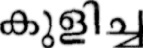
കുളിച്ച
